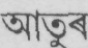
আতুৰ
